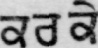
ਕਰਕੇ
